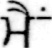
ਮੈਂ
